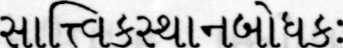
સાત્ત્વિકસ્થાનબોધકઃ
